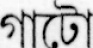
গাটো
